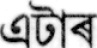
এটাৰ
